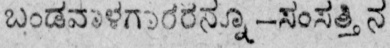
ಬಂಡವಾಳಗಾರರನ್ನೂ-ಸಂಸತ್ತಿನ
